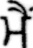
ਮੈਂ
